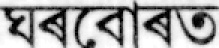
ঘৰবোৰত
